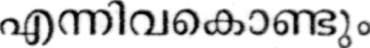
എന്നിവകൊണ്ടും
